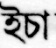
ইচা
